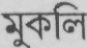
মুকলি
